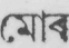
মোৰ
